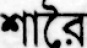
শারৈ
